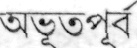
অভূতপূর্ব
